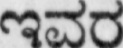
ಇವರ
